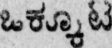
ಒಕ್ಕೂಟ
